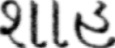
શાહ
